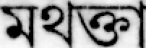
মথক্তা
